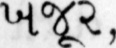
ખજૂર,
